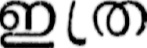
ഇത്ര
